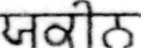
ਯਕੀਨ
